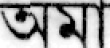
অমা
